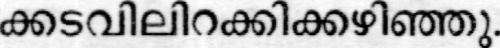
ക്കടവിലിറക്കിക്കഴിഞ്ഞു.
